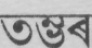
তম্ভৰ
